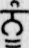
ਨੂੰ
